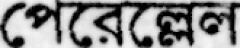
পেরেল্লেল
